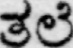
ತಲೆ
